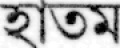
হাতম
